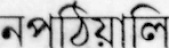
নপঠিয়ালি
